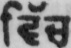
ਵਿੱਚ
